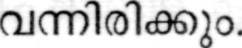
വന്നിരിക്കും.
